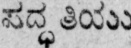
ಪದ್ಧತಿಯು
